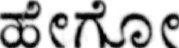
ಹೇಗೋ
